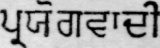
ਪ੍ਰਯੋਗਵਾਦੀ
